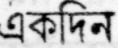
একদিন
